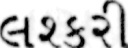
લશ્કરી
